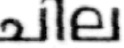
ചില
